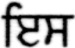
ਇਸ
